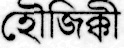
হৌজিক্কী
